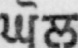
ਘੋਲ
